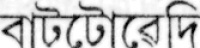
বাটটোৱেদি
